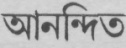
আনন্দিত
